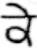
ਕੇ
